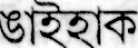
ঙাইহাক
